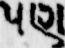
પણ
